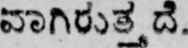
ವಾಗಿರುತ್ತದೆ.
